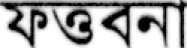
ফত্তবনা
